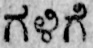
ಗಳಿಗೆ
